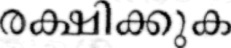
രക്ഷിക്കുക
